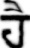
ਹੈ
